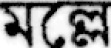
মল্লে
